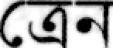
ত্রেন
